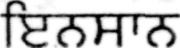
ਇਨਸਾਨ
